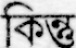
কিন্তু
